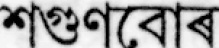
শগুণবোৰ
